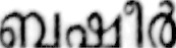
ബഷീര്‍
